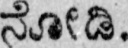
ನೋಡಿ.
